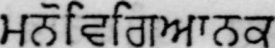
ਮਨੋਵਿਗਿਆਨਕ
